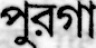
পুরগা
